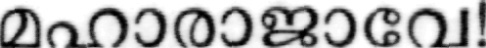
മഹാരാജാവേ!
